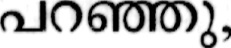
പറഞ്ഞു,
